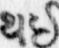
થઈ
